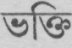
ভক্তি
